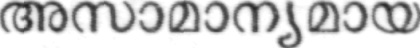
അസാമാന്യമായ
